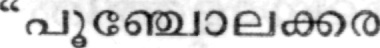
"പൂഞ്ചോലക്കര
